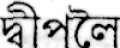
দ্বীপলৈ
